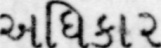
અધિકાર
